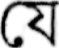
যে
